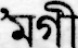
’মগী
